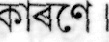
কাৰণে
